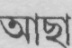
আছা
